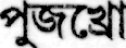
পুজখ্রো
